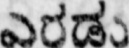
ಎರಡು
